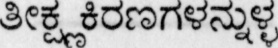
ತೀಕ್ಷ್ಣಕಿರಣಗಳನ್ನುಳ್ಳ
